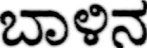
ಬಾಳಿನ
